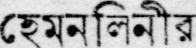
হেমনলিনীর
